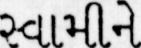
સ્વામીને
